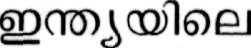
ഇന്ത്യയിലെ
